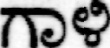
ಗಾಳಿ
